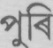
পুৰি
